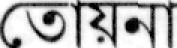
তোয়না
